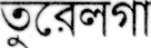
তুরেলগা
